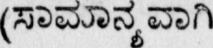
(ಸಾಮಾನ್ಯವಾಗಿ
